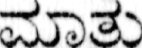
ಮಾತು
